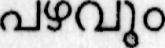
പഴവും
